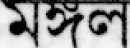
মঙ্গল
